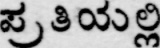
ಪ್ರತಿಯಲ್ಲಿ
